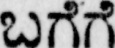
ಬಗೆಗೆ
